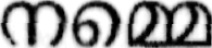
നമ്മെ
